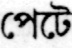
পেটে
